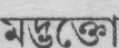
মদ্ভক্তো
